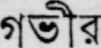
গভীর
